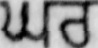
ਘਰ
